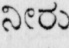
ನೀರು
